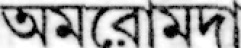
অমরোমদা
